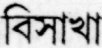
বিসাখা
